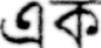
এক
